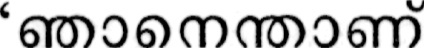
‘ഞാനെന്താണ്
